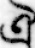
ঐ
